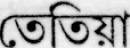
তেতিয়া
